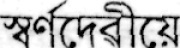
স্বর্ণদেৱীয়ে
